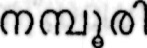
നമ്പൂരി
